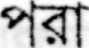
পরা
